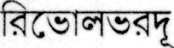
রিভোলভরদূ
